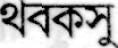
থবকসু
